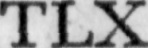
TLX
